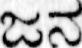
ಜನ
